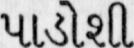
પાડોશી
